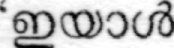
‘ഇയാള്‍
